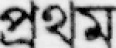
প্রথম
